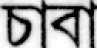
চাবা
